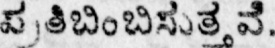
ಪ್ರತಿಬಿಂಬಿಸುತ್ತವೆ.
